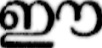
ഈ
